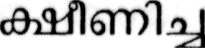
ക്ഷീണിച്ച
